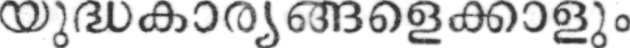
യുദ്ധകാര്യങ്ങളെക്കാളും
